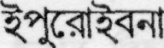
ইপুরোইবনা
